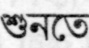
শুনতে
